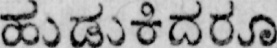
ಹುಡುಕಿದರೂ
